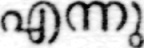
എന്നു
